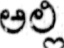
ಅಲ್ಲಿ
